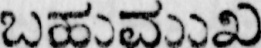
ಬಹುಮುಖ
